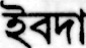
ইবদা
